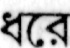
ধরে
